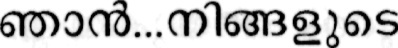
ഞാന്‍...നിങ്ങളുടെ
